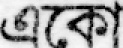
একো
